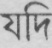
যদি
